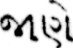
જાણે
